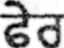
ਫੇਰ
